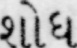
શોધ
